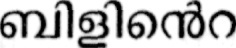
ബിളിന്റെ
